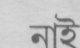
নাই
